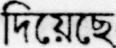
দিয়েছে
